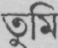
তুমি
